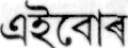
এইবোৰ
